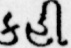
કહી
